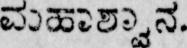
ಮಹಾಶ್ವಾನ.
